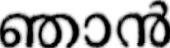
ഞാന്‍
